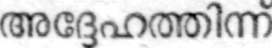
അദ്ദേഹത്തിന്ന്
